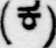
(ಕ)
